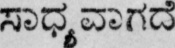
ಸಾಧ್ಯವಾಗದೆ
